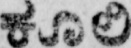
ಕೂಲಿ
